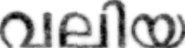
വലിയ
